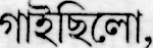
গাইছিলো,
